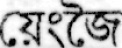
য়েংজৈ
